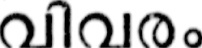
വിവരം
